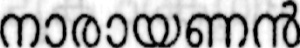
നാരായണന്‍
